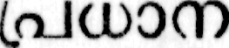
പ്രധാന
